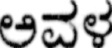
ಅವಳ
